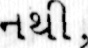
નથી,
